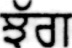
ਝੱਗ
